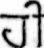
ਹੀ
